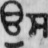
ਉਸ
